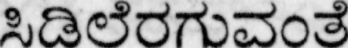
ಸಿಡಿಲೆರಗುವಂತೆ
